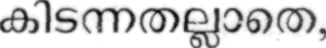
കിടന്നതല്ലാതെ,
